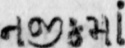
નજીકમાં
